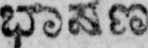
ಭಾಷಣ
